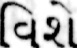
વિશે
